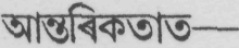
আন্তৰিকতাত-
